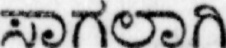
ಸಾಗಲಾಗಿ
